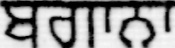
ਬਗਾਨਾ
